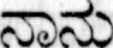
ನಾನು
